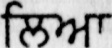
ਲਿਆ
